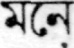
মনে
